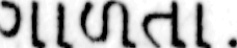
ગાળતા.
